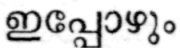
ഇപ്പോഴും
